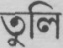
তুলি
